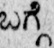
ಬಗ್ಗೆ
